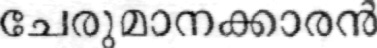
ചേരുമാനക്കാരന്‍
